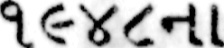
૧૯૪૮ના
